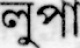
লুপা
